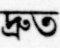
দ্রুত
